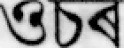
ওচৰ
